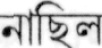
নাছিল
